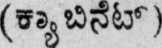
(ಕ್ಯಾಬಿನೆಟ್)
